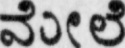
ಮೇಲೆ
